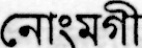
নোংমগী
